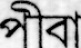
পীবা
